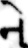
ને
